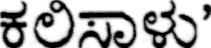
ಕಲಿಸಾಳು'
